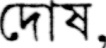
দোষ,
